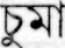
চুমা
